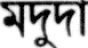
মদুদা
